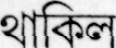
থাকিল
